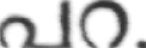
പറ.
